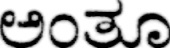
ಅಂತೂ
